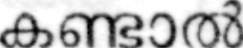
കണ്ടാല്‍
